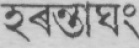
হৰন্তাঘং
